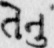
તેનું
